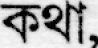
কথা,
